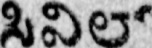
ಸಿವಿಲ್
